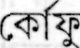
র্কোফু
